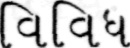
વિવિધ
